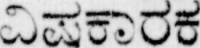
ವಿಷಕಾರಕ
